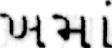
ખમાં
